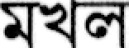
মখল
